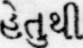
હેતુથી
